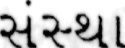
સંસ્થા
